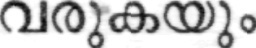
വരുകയും
